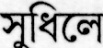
সুধিলে
